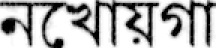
নখোয়গা
